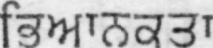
ਭਿਆਨਕਤਾ
